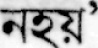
নহয়'
